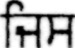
ਜਿਸ
